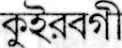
কুইরবগী
